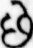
છે
